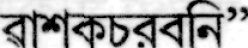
ৱাশকচরবনি”
